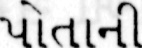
પોતાની
